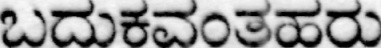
ಬದುಕವಂತಹರು
